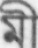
মী
